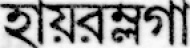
হায়রম্লগা
